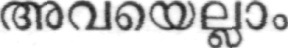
അവയെല്ലാം
